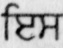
ਇਸ
